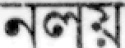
নলয়
